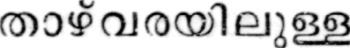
താഴ്വരയിലുള്ള
